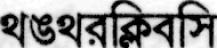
থঙথরক্লিবসি
